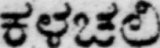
ಕಳಚಲಿ
